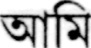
আমি
